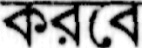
করবে
